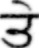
ਤੇ
